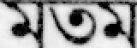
মতম
